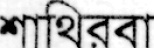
শাখিবা
